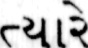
ત્યારે
